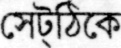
সেট্ঠিকে
